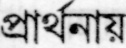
প্রার্থনায়
